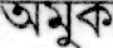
অমুক
